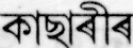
কাছাৰীৰ
